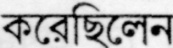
করেছিলেন
